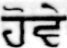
ਹੋਵੇ
